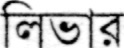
লিভার
